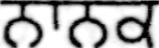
ਨਾਨਕ
